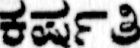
ಕರ್ಷತಿ
